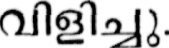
വിളിച്ചു.
